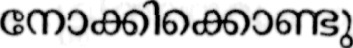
നോക്കിക്കൊണ്ടു
